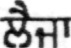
ਲੈਜਾ
